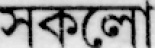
সকলো
